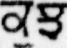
ਕੁਝ
